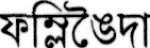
ফম্লিঙৈদা
